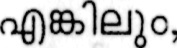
എങ്കിലും,
